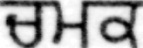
ਚਮਕ
